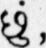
છું,
